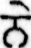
ਨੇ
